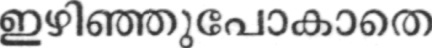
ഇഴിഞ്ഞുപോകാതെ
